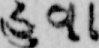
હવા
